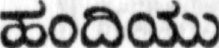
ಹ೦ದಿಯು
